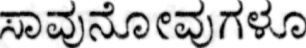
ಸಾವುನೋವುಗಳೂ
